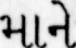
માને
